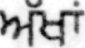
ਅੱਖਾਂ
